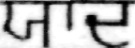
ਯਾਦ
